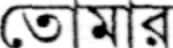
তোমার
